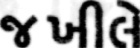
જખીલે
